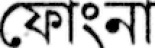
ফোংনা
